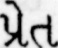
પ્રેત
